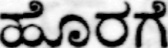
ಹೊರಗೆ
